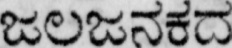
ಜಲಜನಕದ
